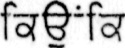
ਕਿਉਂਕਿ
